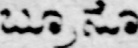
ಬ್ರೂನೊ
